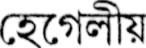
হেগেলীয়
